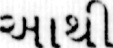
આથી
